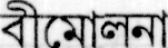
বীমোলনা
